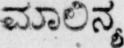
ಮಾಲಿನ್ಯ
